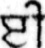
ਈ
